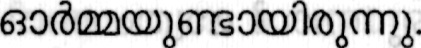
ഓര്‍മ്മയുണ്ടായിരുന്നു.
